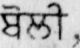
ਬੋਲੀ,
